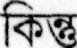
কিন্তু
